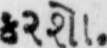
કરશો.
